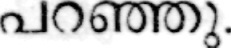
പറഞ്ഞു.
